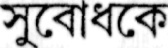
সুবোধকে
